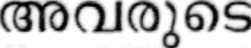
അവരുടെ
